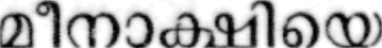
മീനാക്ഷിയെ
